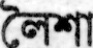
লৈশা
